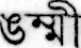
ঙম্মী
